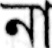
না
